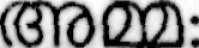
അമ്മ:
